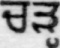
ਚੜ੍ਹ
